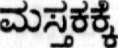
ಮಸ್ತಕಕ್ಕೆ
